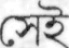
সেই
